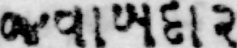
જવાબદાર
